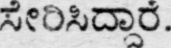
ಸೇರಿಸಿದ್ದಾರೆ.
